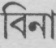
বিনা
